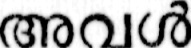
അവള്‍
